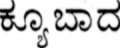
ಕ್ಯೂಬಾದ
